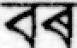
বৰ
